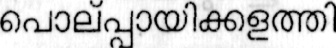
പൊല്പ്പായിക്കളത്തി
